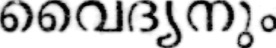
വൈദ്യനും
